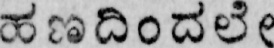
ಹಣದಿಂದಲೇ
